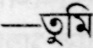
–তুমি
